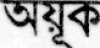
অয়ূক
